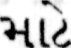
માટે
